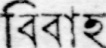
বিবাহ
